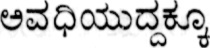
ಅವಧಿಯುದ್ದಕ್ಕೂ
